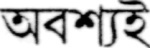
অবশ্যই
